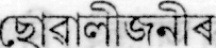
ছোৱালীজনীৰ
